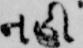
નહીં
